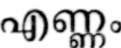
എണ്ണം
